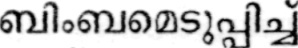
ബിംബമെടുപ്പിച്ച്
